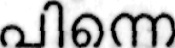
പിന്നെ
